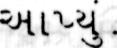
આપ્યું.
